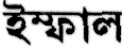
ইম্ফাল
